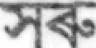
সৰু
